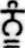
ਨੂੰ
